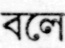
বলে
